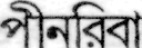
পীনরিবা
